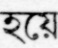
হয়ে
